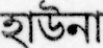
হাউনা
